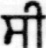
ਸੀ
